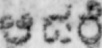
ಆದರೆ
